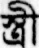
স্ত্রী
